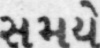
સમયે
